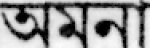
অমনা
